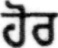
ਹੋਰ
